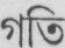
গতি
